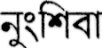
নুংশিবা
